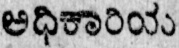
ಅಧಿಕಾರಿಯ
